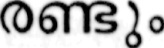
രണ്ടും
